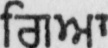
ਗਿਆ
